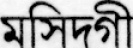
মসিদগী
